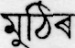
মুঠিৰ
